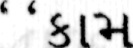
"કામ
